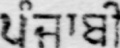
ਪੰਜਾਬੀ
